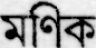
মণিক
